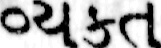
વ્યકત
